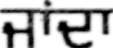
ਜਾਂਦਾ
